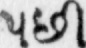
પછી
